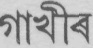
গাখীৰ
